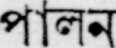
পালন
